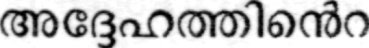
അദ്ദേഹത്തിന്റെ
